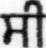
ਸੀ
